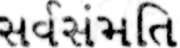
સર્વસંમતિ
